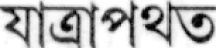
যাত্রাপথত
